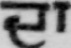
ਦਾ
